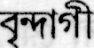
বৃন্দাগী
